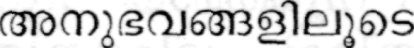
അനുഭവങ്ങളിലൂടെ
